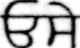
ਓਸੇ
